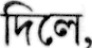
দিলে,
